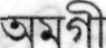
অমগী
